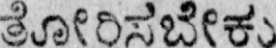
ತೋರಿಸಬೇಕು
